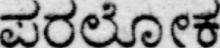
ಪರಲೋಕ
